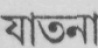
যাতনা
